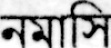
নমাসি
